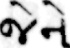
જેને
